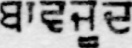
ਬਾਵਜੂਦ
